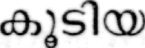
കൂടിയ
